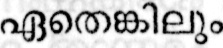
ഏതെങ്കിലും
